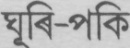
ঘূৰি-পকি
